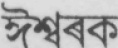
ঈশ্বৰক
